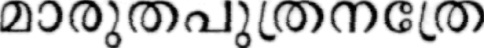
മാരുതപുത്രനത്രേ
